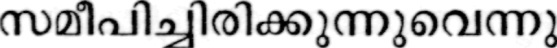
സമീപിച്ചിരിക്കുന്നുവെന്നു
